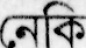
নেকি
